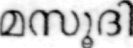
മസൂദി
